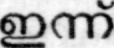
ഇന്ന്
